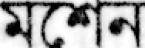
মশেন
